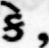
કે,
